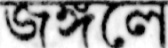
জঙ্গলে
